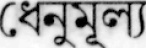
ধেনুমূল্য
